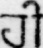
ਹੀ
